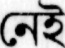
নেই
